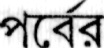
পর্বের
